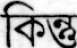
কিন্তু
